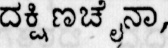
ದಕ್ಷಿಣಚೈನಾ,
